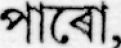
পাৰো,
